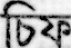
চিফ
